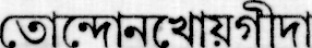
তোন্দোনখোয়গীদা
